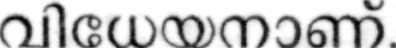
വിധേയനാണ്.
